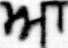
ਆ
